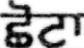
ਛੋਟਾ
